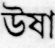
উষা
